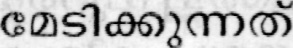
മേടിക്കുന്നത്
